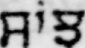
ਸਾਂਝ
